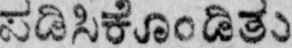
ಪಡಿಸಿಕೊಂಡಿತು
